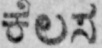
ಕೆಲಸ
